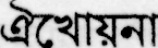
ঐখোয়না
